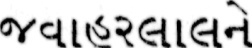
જવાહરલાલને
